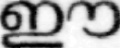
ഈ
